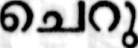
ചെറു
